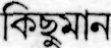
কিছুমান
